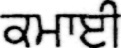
ਕਮਾਈ
